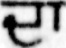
ਦਾ
